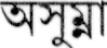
অসুম্না
